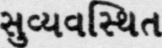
સુવ્યવસ્થિત
